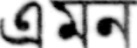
এমন
